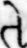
તે
